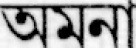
অমনা
